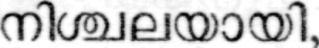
നിശ്ചലയായി,
